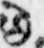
છે.
